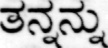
ತನ್ನನ್ನು
